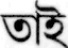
তাই
